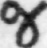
જ
